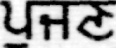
ਪੁਜਣ
